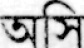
অসি
